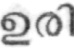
ഉരി
